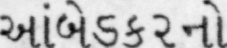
આંબેડકરનો
